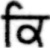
ਕਿ
